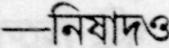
-নিষাদও
